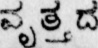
ವೃತ್ತದ
